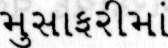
મુસાફરીમાં
